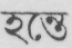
হন্তে
